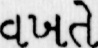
વખતે
